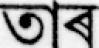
তাৰ
